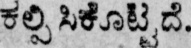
ಕಲ್ಪಿಸಿಕೊಟ್ಟಿದೆ.
